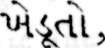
ખેડૂતો,
